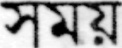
সময়
